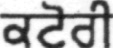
ਕਟੋਰੀ
